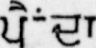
ਪੈਂਦਾ
